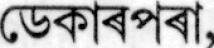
ডেকাৰপৰা,
